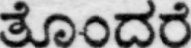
ತೊಂದರೆ
